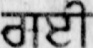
ਗਈ
